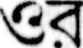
ওর
